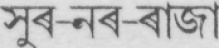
সুৰ-নৰ-ৰাজা
